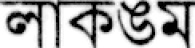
লাকঙম
